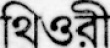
থিওরী
